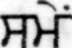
ਸਮੇਂ
